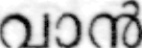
വാന്‍
